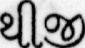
થીજી
